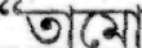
“তামো
